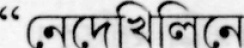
"নেদেখিলিনে
